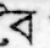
বৈ
